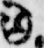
છે.
